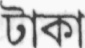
টাকা
